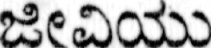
ಜೀವಿಯು
